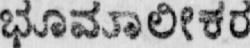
ಭೂಮಾಲೀಕರ
